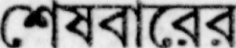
শেষবারের
